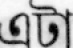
এটা
